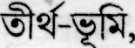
তীর্থ-ভূমি,
